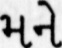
મને
